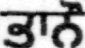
ਭਾਨੌ
